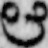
ಆ
